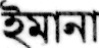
ইমানা
